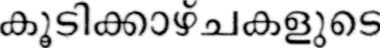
കൂടിക്കാഴ്ചകളുടെ
